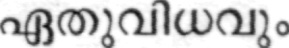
ഏതുവിധവും
